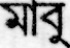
মাবু
